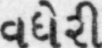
વધેરી
